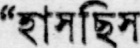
‘‘হাসছিস
